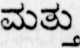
ಮತ್ತು
